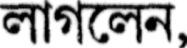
লাগলেন,
